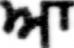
ਆ
